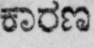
ಕಾರಣ
